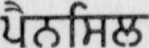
ਪੈਨਸਿਲ
